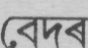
বেদৰ
